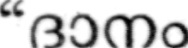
"ദാനം
